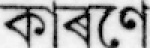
কাৰণে
